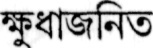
ক্ষুধাজনিত
